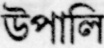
উপালি
